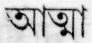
আত্মা
